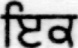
ਇਕ
